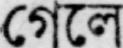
গেলে
